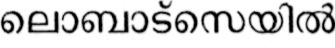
ലൊബാട്സെയില്‍
